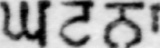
ਘਟਨਾ
